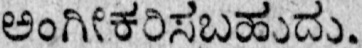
ಅಂಗೀಕರಿಸಬಹುದು.
